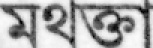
মথক্তা
